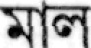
মাল
